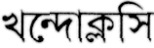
খন্দোক্লসি
